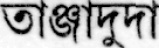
তাঞ্জাদুদা
